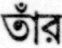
তাঁর
